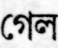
গেল
